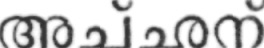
അച്ഛന്
